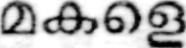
മകളെ
